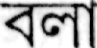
বলা
